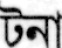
টনা
